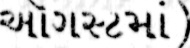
ઑગસ્ટમાં)
